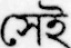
সেই
